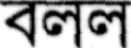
বলল
